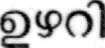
ഉഴറി
